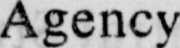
Agency
